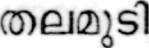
തലമുടി
